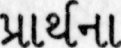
પ્રાર્થના
